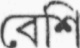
বেশি
